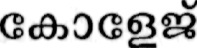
കോളേജ്
